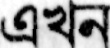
এখন
